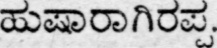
ಹುಷಾರಾಗಿರಪ್ಪ.
